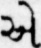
એ
